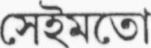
সেইমতো
